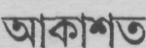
আকাশত
